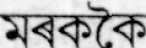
মৰককৈ
